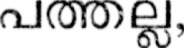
പത്തല്ല,
